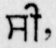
ਸੀ,
